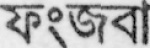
ফংজবা
